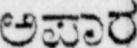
ಅಪಾರ
